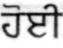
ਹੋਈ
